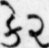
કેર
